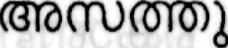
അസത്തു
